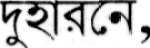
দুহারনে,
